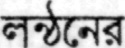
লন্ঠনের
